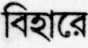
বিহারে
